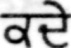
ਕਦੇ
